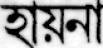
হায়না
